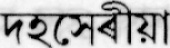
দহসেৰীয়া
